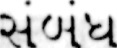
સંબંધ
